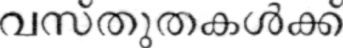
വസ്തുതകള്‍ക്ക്
